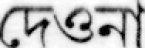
দেওনা
